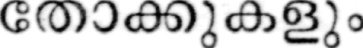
തോക്കുകളും
